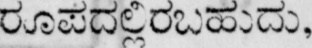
ರೂಪದಲ್ಲಿರಬಹುದು,
